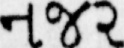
નજર
